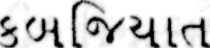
કબજિયાત
